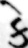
કે
